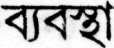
ব্যবস্থা
